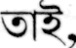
তাই,
